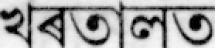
খৰতালত
